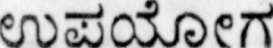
ಉಪಯೋಗ
